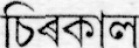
চিৰকাল
